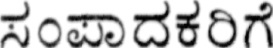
ಸಂಪಾದಕರಿಗೆ
